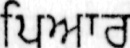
ਪਿਆਰ
